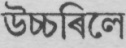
উচ্চৰিলে
